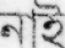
নাই
